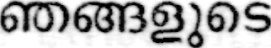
ഞങ്ങളുടെ
